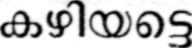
കഴിയട്ടെ
